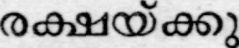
രക്ഷയ്ക്കു
